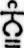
ਨੂੰ
